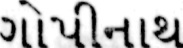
ગોપીનાથ
